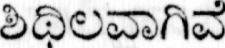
ಶಿಥಿಲವಾಗಿವೆ
